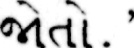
જોતો.'
